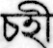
চহী
